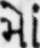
મોં
